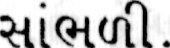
સાંભળી.
